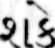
શકે
